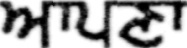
ਆਪਣਾ
